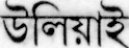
উলিয়াই
